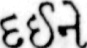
દઈને
